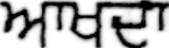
ਆਖਦਾ
